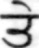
ਤੇ
